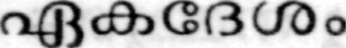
ഏകദേശം
